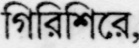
গিরিশিরে,
